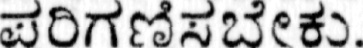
ಪರಿಗಣಿಸಬೇಕು.
